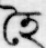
হৈ
